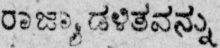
ರಾಜ್ಯಾಡಳಿತವನ್ನು
